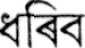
ধৰিব
